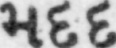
મદદ
